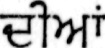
ਦੀਆਂ
